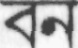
বন
